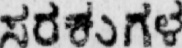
ಸರಕುಗಳ
